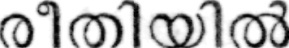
രീതിയില്‍
